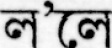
ল'লে
